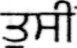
ਤੁਸੀ
